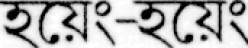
হয়েং-হয়েং
